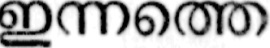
ഇന്നത്തെ
